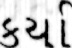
કર્યા
